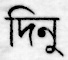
দিনু
